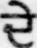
ਦੇ
